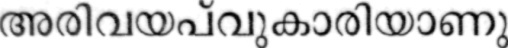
അരിവയപ്വുകാരിയാണു
